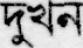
দুখন
